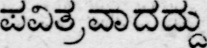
ಪವಿತ್ರವಾದದ್ದು
